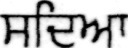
ਸਦਿਆ
